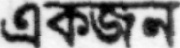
একজন
